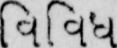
વિવિધ
